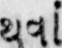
થવાં
